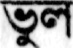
ভুল
